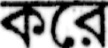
করে
